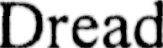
Dread
